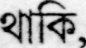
থাকি,
